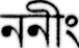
ননীং
